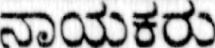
ನಾಯಕರು
